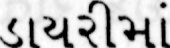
ડાયરીમાં
